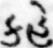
કહે
